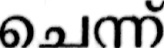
ചെന്ന്
